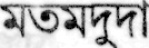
মতমদুদা
